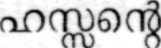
ഹസ്സന്റെ
